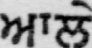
ਆਲੇ
